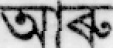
আৰু
